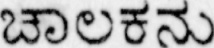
ಚಾಲಕನು
